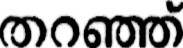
തറഞ്ഞ്
